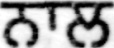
ਨਾਲ
